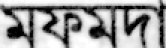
মফমদা
